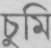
চুমি
